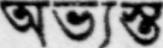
অভ্যস্ত
